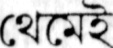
থেমেই
